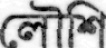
লৌশি
